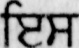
ਇਸ
